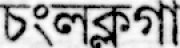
চংলক্লগা
